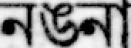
নঙনা
